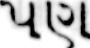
પણ
